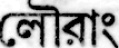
লৌরাং
